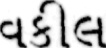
વકીલ
